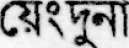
য়েংদুনা
